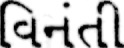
વિનંતી
